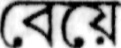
বেয়ে
